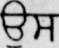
ਉਸ
